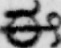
ಈ
